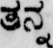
ತನ್ನ
